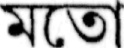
মতো
